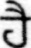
ਹੈ
